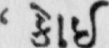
'કોઈ
